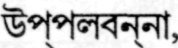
উপ্পলবন্না,
